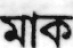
মাক
